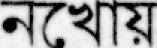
নখোয়
